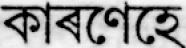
কাৰণেহে
